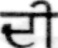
ਦੀ
